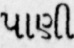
પાણી
